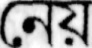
নেয়
